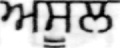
ਅਸੂਲ
